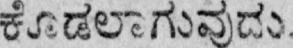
ಕೊಡಲಾಗುವುದು.
